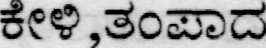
ಕೇಳಿ,ತಂಪಾದ
